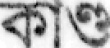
কাণ্ড
